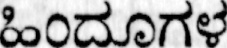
ಹಿಂದೂಗಳ
